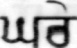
ਘਰੇ
